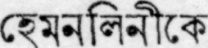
হেমনলিনীকে
